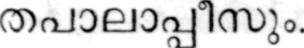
തപാലാപ്പീസും.
